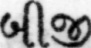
બીજી
